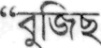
"বুজিছ
